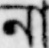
না
